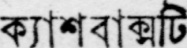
ক্যাশবাক্সটি
